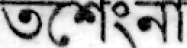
তশেংনা
